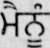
ਮੈਨੂੰ
